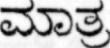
ಮಾತ್ರ
